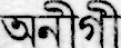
অনীগী
